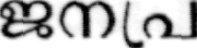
ജനപ്ര
